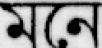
মনে
